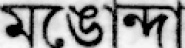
মঙোন্দা
